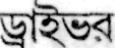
ড্রাইভর
